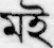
মই
